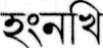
হংনখি
